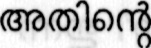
അതിന്റെ
